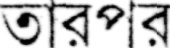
তারপর
